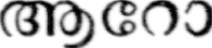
ആറോ
